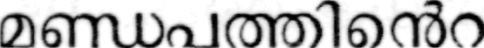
മണ്ഡപത്തിന്റെ
